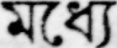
মধ্যে
